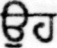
ਉਹ
